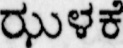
ಝಳಕೆ
